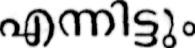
എന്നിട്ടും
